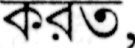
করত,
